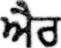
ਐਰ
